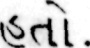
હતો.
